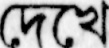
দেখে
